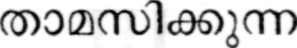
താമസിക്കുന്ന
